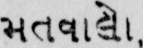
મતવાલો,
